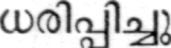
ധരിപ്പിച്ചു
